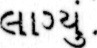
લાગ્યું.
